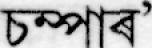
চম্পাৰ'
